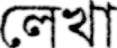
লেখা
